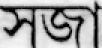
সজা
